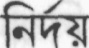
নির্দয়
